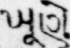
ખૂણે
